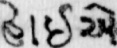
હોઈએ
